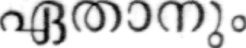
ഏതാനും
